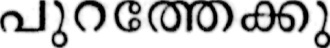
പുറത്തേക്കു
